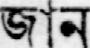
জান
